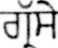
ਗ੍ਰੱਸੇ
